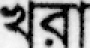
খরা
